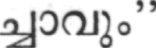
ച്ചാവും"
